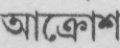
আক্ৰোশ
